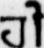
ਹੀ
